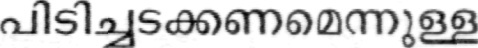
പിടിച്ചടക്കണമെന്നുള്ള
